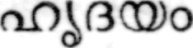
ഹൃദയം
